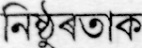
নিষ্ঠুৰতাক
